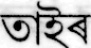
তাইৰ
